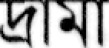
দ্রামা
